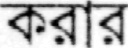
করার
